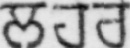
ਲਹਰ
